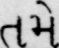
તમે
